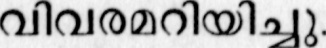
വിവരമറിയിച്ചു.
